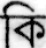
কি
